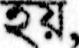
হয়,
